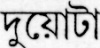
দুয়োটা
